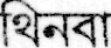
থিনবা
